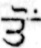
ਤੋਂ
